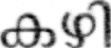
കഴി
